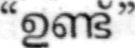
“ഉണ്ട്”
